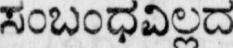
ಸಂಬಂಧವಿಲ್ಲದ
